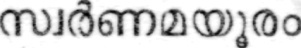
സ്വര്‍ണമയൂരം
